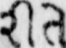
રીતે
